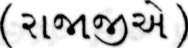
(રાજાજીએ)
